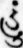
હું
